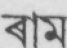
ৰাম
